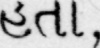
હતા,
